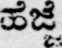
ಹೆಜ್ಜೆ
